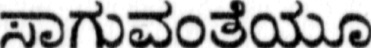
ಸಾಗುವಂತೆಯೂ
